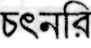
চৎনরি
